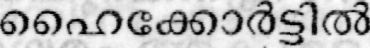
ഹൈക്കോര്‍ട്ടില്‍
